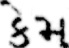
કેમ
